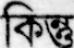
কিন্তু
